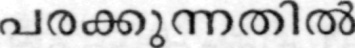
പരക്കുന്നതില്‍
